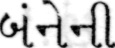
બંનેની
